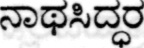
ನಾಥಸಿದ್ಧರ
